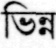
ভিন্ন
